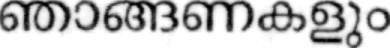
ഞാങ്ങണകളും
